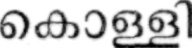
കൊള്ളി
